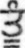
ਤੂੰ
